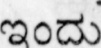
ಇಂದು
